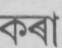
কৰা
